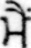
ਮੈਂ
